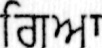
ਗਿਆ
